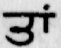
ਤਾਂ
